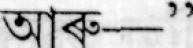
আৰু-"
